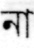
না
